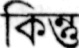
কিন্তু
